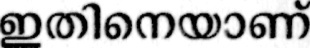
ഇതിനെയാണ്
